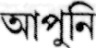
আপুনি
